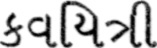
કવિયિત્રી
